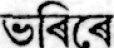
ভৰিৰে
